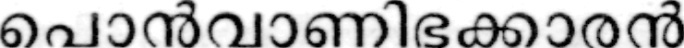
പൊന്‍വാണിഭക്കാരന്‍
